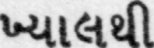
ખ્યાલથી
